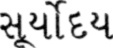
સૂર્યોદય
